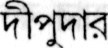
দীপুদার
